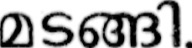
മടങ്ങി.
